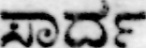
ಸಾರ್ದ
